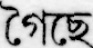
গৈছে
